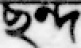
ছন্দ
